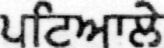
ਪਟਿਆਲੇ
